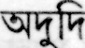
অদুদি
